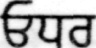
ਓਧਰ
